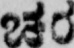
ಚರ
